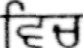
ਵਿਚ
